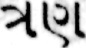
ત્રણ
